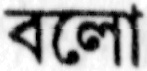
বলো
